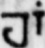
ਹਾਂ
